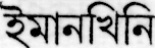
ইমানখিনি
